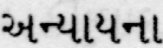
અન્યાયના
